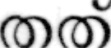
തത്
